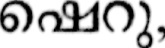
ഷെറു,
